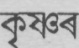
কৃষ্ণৰ
